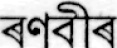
ৰণবীৰ
